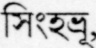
সিংহভ্রূ,
